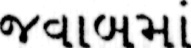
જવાબમાં
